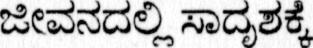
ಜೀವನದಲ್ಲಿಸಾದೃಶಕ್ಕೆ
